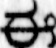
ಈ
